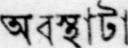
অবস্থাটা
